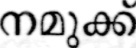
നമുക്ക്
